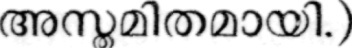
അസ്തമിതമായി.)
